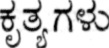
ಕೃತ್ಯಗಳು
